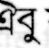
ঐবু
